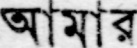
আমার
